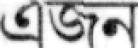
এজন
